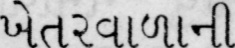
ખેતરવાળાની
